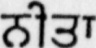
ਨੀਤਾ
